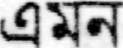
এমন
